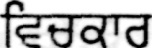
ਵਿਚਕਾਰ
